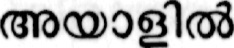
അയാളില്‍
